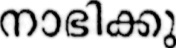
നാഭിക്കു
